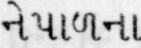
નેપાળના
